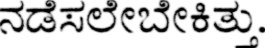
ನಡೆಸಲೇಬೇಕಿತ್ತು.
